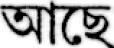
আছে
